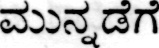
ಮುನ್ನಡೆಗೆ
